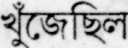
খুঁজেছিল
